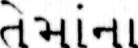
તેમાંના
